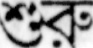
শুরু
